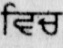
ਵਿਚ
